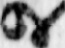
જ
